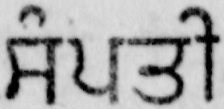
ਸੰਪਤੀ
